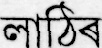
লাঠিৰ
